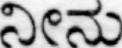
ನೀನು
